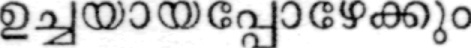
ഉച്ചയായപ്പോഴേക്കും
